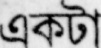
একটা
